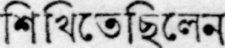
শিখিতেছিলেন
